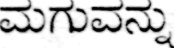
ಮಗುವನ್ನು
